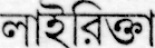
লাইরিক্তা
